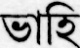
ভাহি
